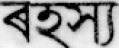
ৰহস্য
